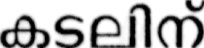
കടലിന്
